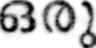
ഒരു
